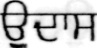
ਉਦਾਸ
